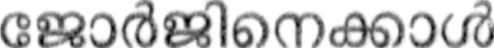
ജോര്‍ജിനെക്കാള്‍
